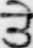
ਤੇ
